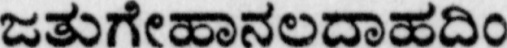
ಜತುಗೇಹಾನಲದಾಹದಿಂ
